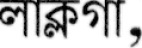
লাক্লগা,
